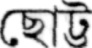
ছোট্ট
